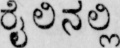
ರೈಲಿನಲ್ಲಿ
